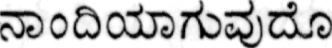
ನಾಂದಿಯಾಗುವುದೊ
